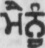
ਮੈਨੂੰ
